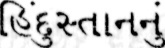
હિંદુસ્તાનનું
